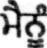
ਮੈਨੂੰ
